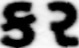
કર
